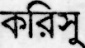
করিসু
